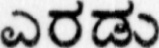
ಎರಡು
